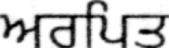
ਅਰਪਿਤ
